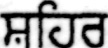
ਸ਼ਹਿਰ
